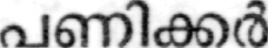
പണിക്കര്‍
